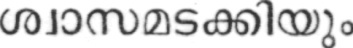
ശ്വാസമടക്കിയും
